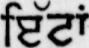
ਇੱਟਾਂ
